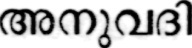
അനുവദി
